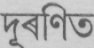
দূৰণিত
